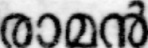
രാമന്‍
